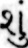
શું
